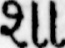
શા
